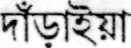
দাঁড়াইয়া
